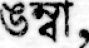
ঙম্বা,
